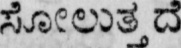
ಸೋಲುತ್ತದೆ
